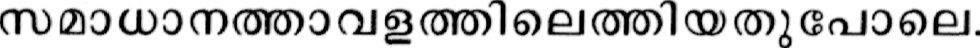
സമാധാനത്താവളത്തിലെത്തിയതുപോലെ
